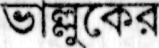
ভাল্লুকের
